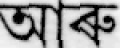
আৰু
